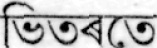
ভিতৰতে
